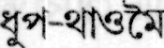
ধুপ-থাওমৈ
